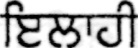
ਇਲਾਹੀ
